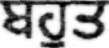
ਬਹੁਤ
